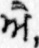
ਐ,
